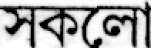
সকলো
